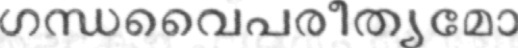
ഗന്ധവൈപരീത്യമോ
